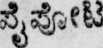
ಪೈಪೋಟಿ
